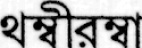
থম্বীরম্বা
